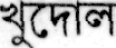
খুদোল
